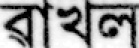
ৱাখল
